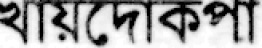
খায়দোকপা
